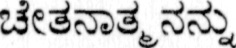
ಚೇತನಾತ್ಮನನ್ನು
